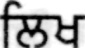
ਲਿਖ
